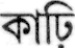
কাঢ়ি
